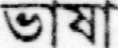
ভাষা
